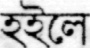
হইলে
